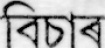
বিচাৰ
